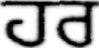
ਹਰ
